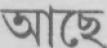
আছে
